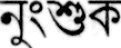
নুংশুক
